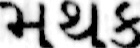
મથક
